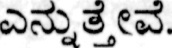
ಎನ್ನುತ್ತೇವೆ.
